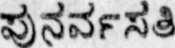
ಪುನರ್ವಸತಿ
